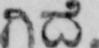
ಗಿದೆ.
